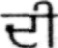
ਦੀ
